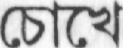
চোখে
